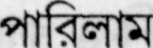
পারিলাম
